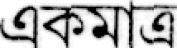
একমাত্র
